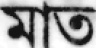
মাত
